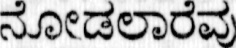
ನೋಡಲಾರೆವು
